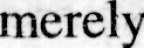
merely
